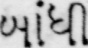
બાંધી
